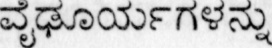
ವೈಢೂರ್ಯಗಳನ್ನು
